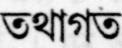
তথাগত
